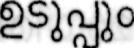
ഉടുപ്പും
